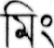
মিং
